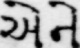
એને
